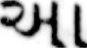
આ
